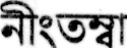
নীংতম্বা
